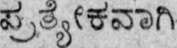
ಪ್ರತ್ಯೇಕವಾಗಿ
